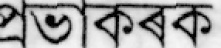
প্রভাকৰক
